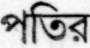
পতির
